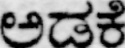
ಅಡಕೆ
